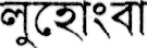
লুহোংবা
